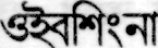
ওইবশিংনা
